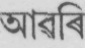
আৱৰি
